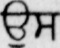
ਉਸ
